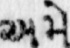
અમે
